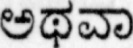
ಅಥವಾ
